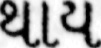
થાય
